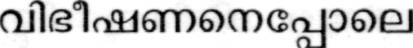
വിഭീഷണനെപ്പോലെ
